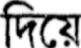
দিয়ে
